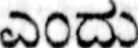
ಎಂದು
